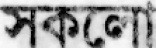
সকলো
